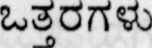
ಒತ್ತರಗಳು
